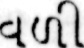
વળી
